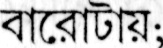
বারোটায়;
